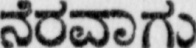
ನೆರವಾಗು
